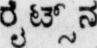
ರೈಟ್ಸ್‌ನ
